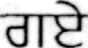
ਗਏ
